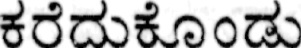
ಕರೆದುಕೊಂಡು
